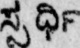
ಸ್ಪರ್ಧಿ
